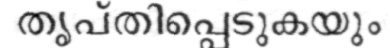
തൃപ്തിപ്പെടുകയും
